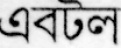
এবটল
